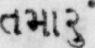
તમારું
